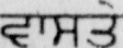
ਵਾਸਤੇ
